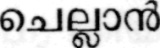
ചെല്ലാന്‍
